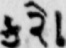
કરો
